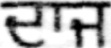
ਦਾਜ
